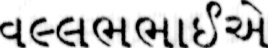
વલ્લભભાઈએ
